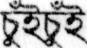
চুঁইচুঁই
